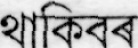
থাকিবৰ
